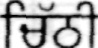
ਚਿੱਠੀ
